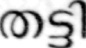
തട്ടി
